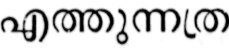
എത്തുന്നത്ര
